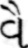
વૈ
